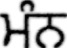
ਮੰਨ
